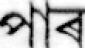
পাৰ
